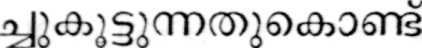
ച്ചുകുട്ടുന്നതുകൊണ്ട്
